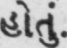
હોતું.
